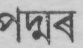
পদ্মৰ
